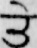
ਤੇ
